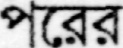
পরের
